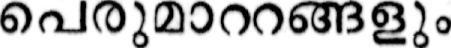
പെരുമാററങ്ങളും
